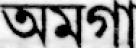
অমগা
